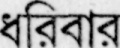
ধরিবার
